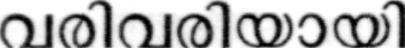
വരിവരിയായി
